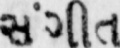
સંગીત
